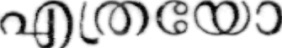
എത്രയോ
